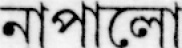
নাপালো
